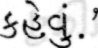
કહેવું.'
